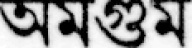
অমগুম
